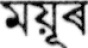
ময়ূৰ
